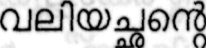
വലിയച്ഛന്റെ
